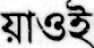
য়াওই
